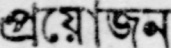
প্রয়োজন
